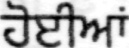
ਹੋਈਆਂ
